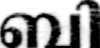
ബി
